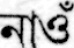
নাওঁ
